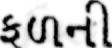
ફળની
